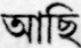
আছি
